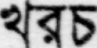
খরচ
